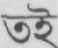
তই
